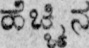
ಹೆಚ್ಚಿನ
